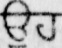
ਉਹ
